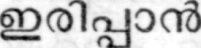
ഇരിപ്പാന്‍
